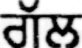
ਗੱਲ
